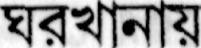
ঘরখানায়
